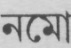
নমো
